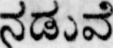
ನಡುವೆ
